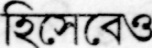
হিসেবেও
